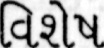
વિશેષ
